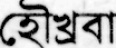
হৌখ্রবা
